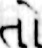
તો
